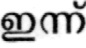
ഇന്ന്
